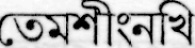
তেমশীংনখি
